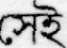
সেই
